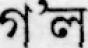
গ'ল
